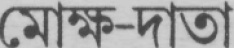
মোক্ষ-দাতা
